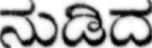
ನುಡಿದ
